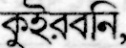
কুইরবনি,
